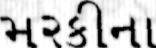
મરકીના
